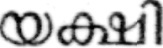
യക്ഷി
